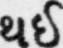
થઈ
